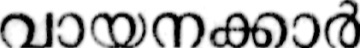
വായനക്കാര്‍
